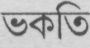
ভকতি
